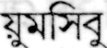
য়ুমসিবু
